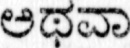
ಅಥವಾ
